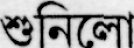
শুনিলো
